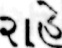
રાહે
